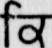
ਕਿ
